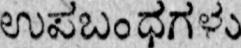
ಉಪಬಂಧಗಳು
